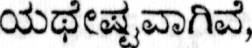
ಯಥೇಷ್ಟವಾಗಿವೆ,
